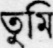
তুমি
